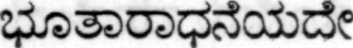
ಭೂತಾರಾಧನೆಯದೇ
